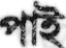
পাই
